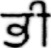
ਭੀ
